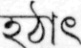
হঠাৎ
